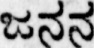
ಜನನ
